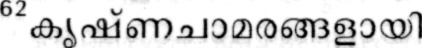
62കൃഷ്ണചാമരങ്ങളായി
